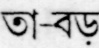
তা-বড়
